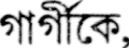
গার্গীকে,
